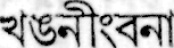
খঙনীংবনা
